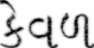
કેવળ
